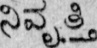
ನಿವೃತ್ತಿ
